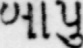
બાપુ
